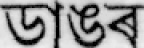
ডাঙৰ
